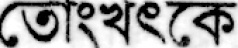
তোংখৎকে
